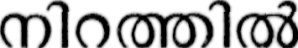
നിറത്തില്‍
